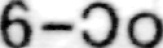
6-ാം
